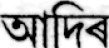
আদিৰ
